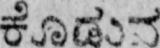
ಕೊಡುವ
